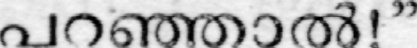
പറഞ്ഞാല്‍!"
